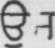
ਉਸ
